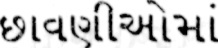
છાવણીઓમાં
